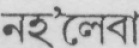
নহ'লেবা
